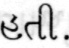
હતી.
